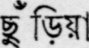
ছুঁড়িয়া
